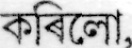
কৰিলো,
